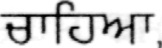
ਚਾਹਿਆ,
